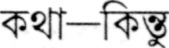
কথা–কিন্তু
